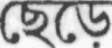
ছেড়ে
